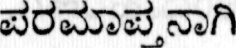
ಪರಮಾಪ್ತನಾಗಿ
